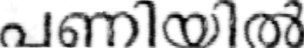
പണിയില്‍
